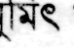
নুমিৎ
